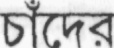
চাঁদের
